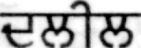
ਦਲੀਲ
